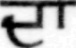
ਦਾ
